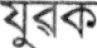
যুৱক
